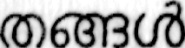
തങ്ങള്‍
